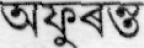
অফুৰন্ত
